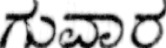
ಗುವಾರ
